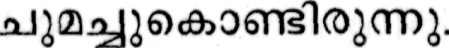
ചുമച്ചുകൊണ്ടിരുന്നു.
